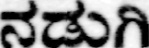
ನಡುಗಿ
